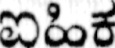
ಐಹಿಕ
